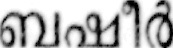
ബഷീര്‍
